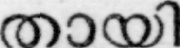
തായി
